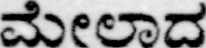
ಮೇಲಾದ
